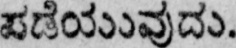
ಪಡೆಯುವುದು.
